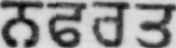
ਨਫਰਤ
